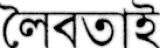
লৈবতাই
